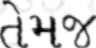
તેમજ
